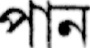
পান
